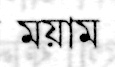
ময়াম
